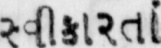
સ્વીકારતાં
